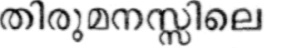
തിരുമനസ്സിലെ
